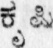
ಕೃಷಿ
